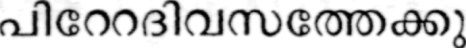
പിറേറദിവസത്തേക്കു
